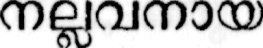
നല്ലവനായ
